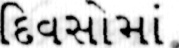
દિવસોમાં
